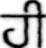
ਹੀ
